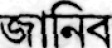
জানিব
